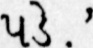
પડે.'
